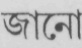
জানো
